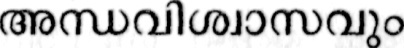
അന്ധവിശ്വാസവും
